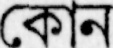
কোন
